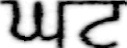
ਘਟ
